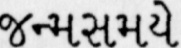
જન્મસમયે
